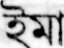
ইমা
